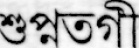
শুপ্নতগী
